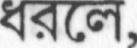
ধরলে,
